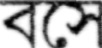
বসে
